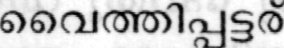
വൈത്തിപ്പട്ടര്
